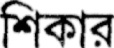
শিকার
